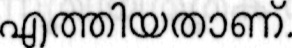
എത്തിയതാണ്.
